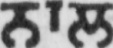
ਨਾਲ
